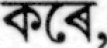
কৰে,
